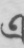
এ
